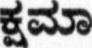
ಕ್ಷಮಾ
